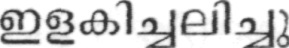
ഇളകിച്ചലിച്ചു
